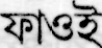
ফাওই
